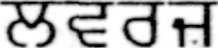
ਲਵਰਜ਼
